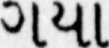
ગયા
